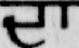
ਦਾ
